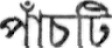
পাঁচটি
